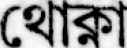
থোক্না
